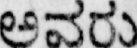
ಅವರು
